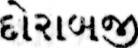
દોરાબજી
